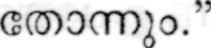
തോന്നും.”
